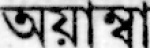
অয়াম্বা
